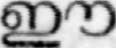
ഈ
